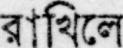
রাখিলে
